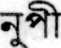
নুপী
